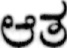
ಆತ
